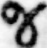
જ
